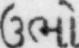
ઉભો
